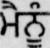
ਮੈਨੂੰ
